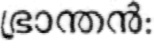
ഭ്രാന്തന്‍:
